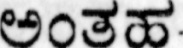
ಅಂತಹ
